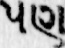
પણ
